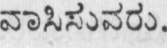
ವಾಸಿಸುವರು.
